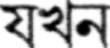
যখন
